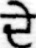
ਦੇ
